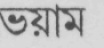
ভৈয়াম
